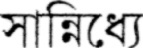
সান্নিধ্যে
